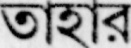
তাহার
